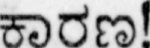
ಕಾರಣ!
